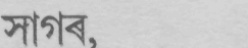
সাগৰ,
